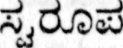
ಸ್ವರೂಪ
